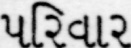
પરિવાર
